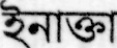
ইনাক্তা
